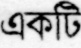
একটি
